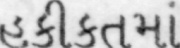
હકીકતમાં
